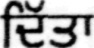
ਦਿੱਤਾ
